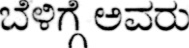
ಬೆಳಿಗ್ಗೆಅವರು
